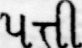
પત્તી
